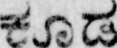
ಕೂಡ
